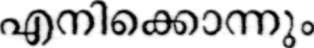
എനിക്കൊന്നും
